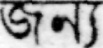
জন্য
